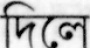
দিলে
